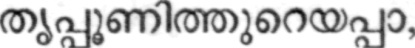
തൃപ്പൂണിത്തുറെയപ്പാ,
